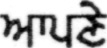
ਆਪਣੇ
